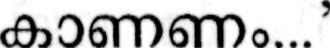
കാണണം...’
